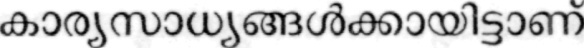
കാര്യസാധ്യങ്ങള്‍ക്കായിട്ടാണ്
